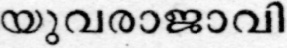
യുവരാജാവി
